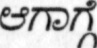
ಆಗಾಗ್ಗೆ
